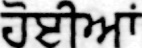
ਹੋਈਆਂ
